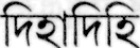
দিহাদিহি
